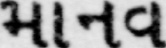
માનવ
